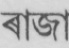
ৰাজা
